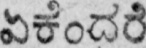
ಏಕೆಂದರೆ
